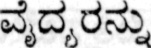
ವೈದ್ಯರನ್ನು
